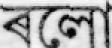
ৰলো
